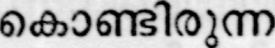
കൊണ്ടിരുന്ന
